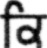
ਕਿ
